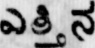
ಎತ್ತಿನ
